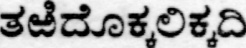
ತಱೆದೊಕ್ಕಲಿಕ್ಕದಿ
